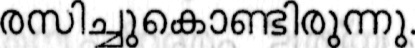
രസിച്ചുകൊണ്ടിരുന്നു.
